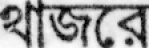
থাজরে
